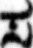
ಸ
